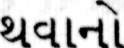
થવાનો
